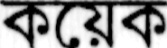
কয়েক
